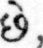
છે,
